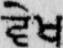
ਵੇਖ
